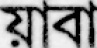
য়াবা
